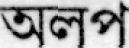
অলপ
